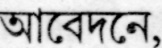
আবেদনে,
